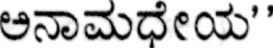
ಅನಾಮಧೇಯ"
